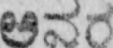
ಅವರ
